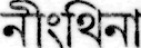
নীংথিনা
